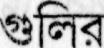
গুলির
